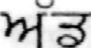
ਅੱਡ
